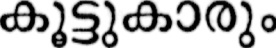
കൂട്ടുകാരും
